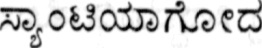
ಸ್ಯಾಂಟಿಯಾಗೋದ
